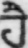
ਹੈ
